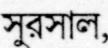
সুরসাল,
